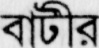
বাটীর
